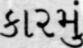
કારમું
